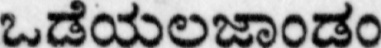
ಒಡೆಯಲಜಾಂಡಂ
